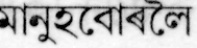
মানুহবোৰলৈ
